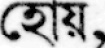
হোয়,
